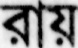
রায়
